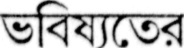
ভবিষ্যতের
